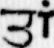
ਤਾਂ
